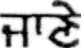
ਜਾਣੇ
